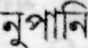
নুপানি
